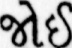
જોઈ
